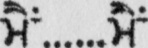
ਮੈਂ............ਮੈਂ
